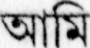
আমি
